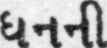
ધનની
